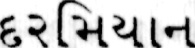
દરમિયાન
